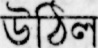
উঠিল
